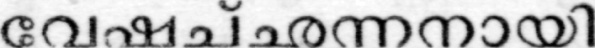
വേഷച്ഛന്നനായി
